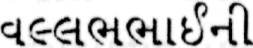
વલ્લભભાઈની
